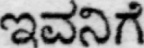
ಇವನಿಗೆ
